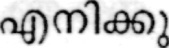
എനിക്കു
